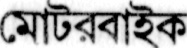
মোটরবাইক
